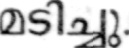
മടിച്ചു.
